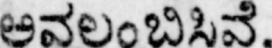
ಅವಲಂಬಿಸಿವೆ.
